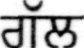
ਗੱਲ
